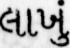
લાખું
